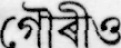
গৌৰীও
